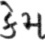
કેમ
